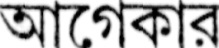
আগেকার
